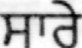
ਸਾਰੇ
